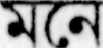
মনে
